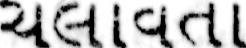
ચલાવતા
